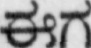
ಈಗ
